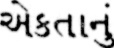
એકતાનું
